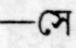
–সে
